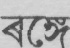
ৰঙ্গে
